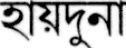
হায়দুনা
